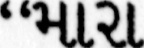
"મારા
